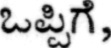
ಒಪ್ಪಿಗೆ,
